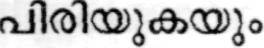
പിരിയുകയും
